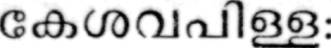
കേശവപിള്ള:
